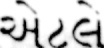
એટલે
